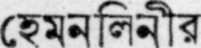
হেমনলিনীর
